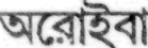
অরোইবা
